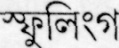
স্ফুলিংগ
